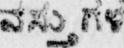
ವಸ್ತುಗಳ
